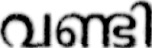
വണ്ടി
